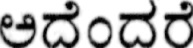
ಅದೆಂದರೆ
